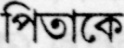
পিতাকে
